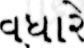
વધારે
